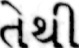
તેથી
